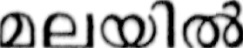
മലയില്‍
